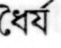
ধৈর্য
